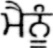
ਮੈਨੂੰ
